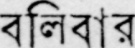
বলিবার
